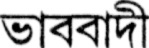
ভাববাদী
